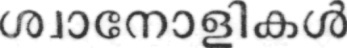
ശ്വാനോളികള്‍
